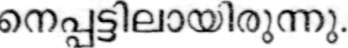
നെപ്പട്ടിലായിരുന്നു.
